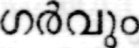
ഗര്‍വും
